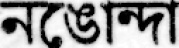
নঙোন্দা
